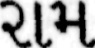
રામ
